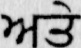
ਅਤੇ
